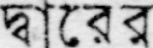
দ্বারের
